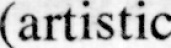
(artistic
